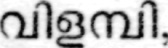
വിളമ്പി,
